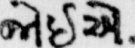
જોઈએ.
